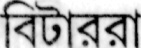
বিটাররা
